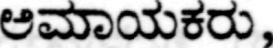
ಅಮಾಯಕರು,
